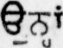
ਉਨ੍ਹਾਂ
